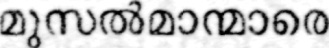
മുസല്‍മാന്മാരെ
